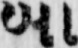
બા
